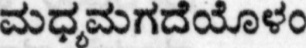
ಮಧ್ಯಮಗದೆಯೊಳಂ
